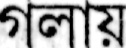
গলায়
